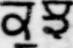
ਕੁਝ
